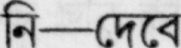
নি-দেবে
